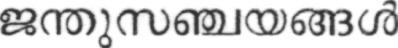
ജന്തുസഞ്ചയങ്ങള്‍
